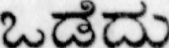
ಒಡೆದು
